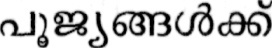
പൂജ്യങ്ങള്‍ക്ക്
